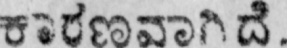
ಕಾರಣವಾಗಿದೆ.
